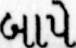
બાપે
